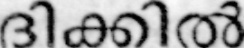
ദിക്കില്‍
